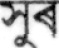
সুৰ
